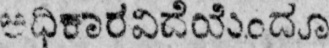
ಅಧಿಕಾರವಿದೆಯೆಂದೂ
